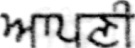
ਆਪਣੀ
